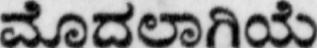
ಮೊದಲಾಗಿಯೆ
